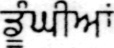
ਡੂੰਘੀਆਂ
